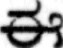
ಈ
